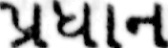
પ્રધાન
